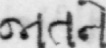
જાતને
